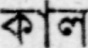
কাল
